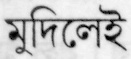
মুদিলেই
